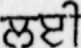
ਲਈ
